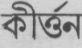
কীৰ্ত্তন
